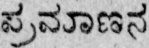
ಪ್ರಮಾಣನ
